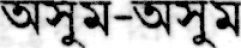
অসুম-অসুম
